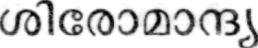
ശിരോമാന്ദ്യ
